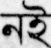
নই
